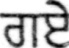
ਗਏ
